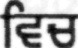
ਵਿਚ
